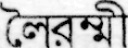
লৈরম্মী
